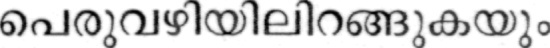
പെരുവഴിയിലിറങ്ങുകയും
